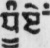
ਧੂੰਏਂ
